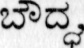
ಬೌದ್ಧ,
